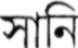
সানি
